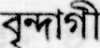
বৃন্দাগী
